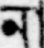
না
